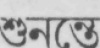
শুনন্তে
